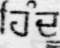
ਹਿੰਦੂ
